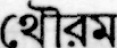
থৌরম
